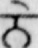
ਨੇ
